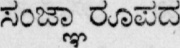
ಸಂಜ್ಞಾರೂಪದ
